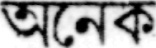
অনেক
